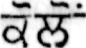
ਕੋਲੋਂ
